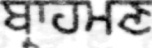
ਬ੍ਰਾਹਮਣ
